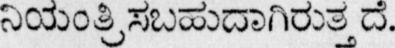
ನಿಯಂತ್ರಿಸಬಹುದಾಗಿರುತ್ತದೆ.
